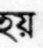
হয়
